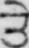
ਤੇ
